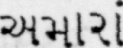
અમારાં
